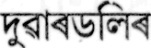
দুৱাৰডলিৰ
